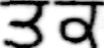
ਤਕ
